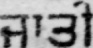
ਜਾਤੀ
